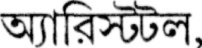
অ্যারিস্টটল,
